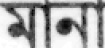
মানা
